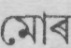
মোৰ
